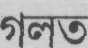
গলত
